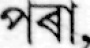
পৰা,
